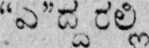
“ಎ”ದ್ದರಲ್ಲಿ
